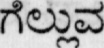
ಗೆಲ್ಲುವ
